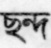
ছন্দ
